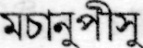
মচানুপীসু
